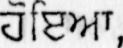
ਹੋਇਆ,
